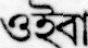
ওইবা
